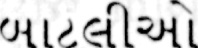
બાટલીઓ
